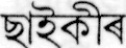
ছাইকীৰ
